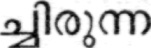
ച്ചിരുന്ന
